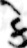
કે
